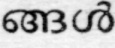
ങ്ങള്‍
